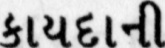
કાયદાની
